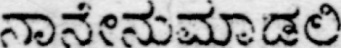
ನಾನೇನುಮಾಡಲಿ
